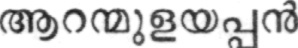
ആറന്മുളയപ്പന്‍
